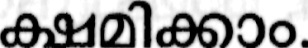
ക്ഷമിക്കാം.
